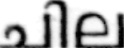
ചില
